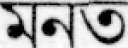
মনত
